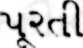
પૂરતી
